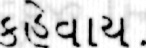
કહેવાય.
